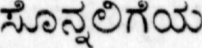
ಸೊನ್ನಲಿಗೆಯ
